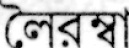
লৈরম্বা
